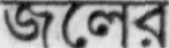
জলের
